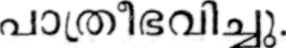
പാത്രീഭവിച്ചു.
